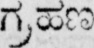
ಗ್ರಹಣ
